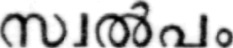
സ്വല്‍പം
